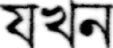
যখন
